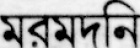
মরমদনি
